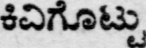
ಕಿವಿಗೊಟ್ಟು
